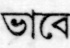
ভাবে
